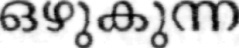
ഒഴുകുന്ന
